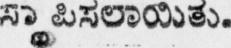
ಸ್ಥಾಪಿಸಲಾಯಿತು.
